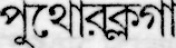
পুথোরক্লগা
